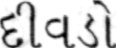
દીવડો
